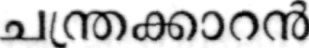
ചന്ത്രക്കാറന്‍
